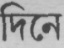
দিনে
